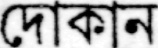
দোকান
